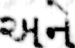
અને
